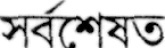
সর্বশেষত
